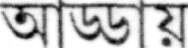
আড্ডায়
